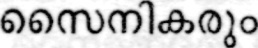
സൈനികരും
